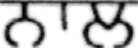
ਨਾਲ
